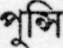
পুন্সি
